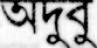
অদুবু
